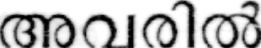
അവരില്‍
